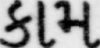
કામ
